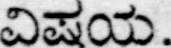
ವಿಷಯ.
